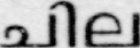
ചില
